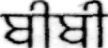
ਬੀਬੀ
